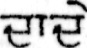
ਦਾਦੇ
